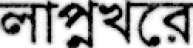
লাপ্নখরে
